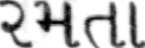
રમતા
